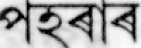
পহৰাৰ
